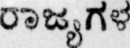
ರಾಜ್ಯಗಳ
